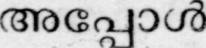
അപ്പോള്‍
